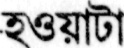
হওয়াটা
